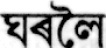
ঘৰলৈ
